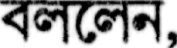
বললেন,
